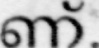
ണ്.
